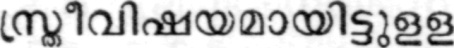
സ്ത്രീവിഷയമായിട്ടുള്ള
